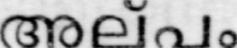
അല്പം
